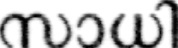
സാധി
